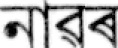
নাৱৰ
